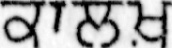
ਕਾਲਖ਼
